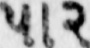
પાર
